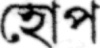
হোপ
